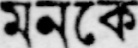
মনকে
